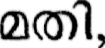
മതി,
